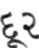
દૂર
